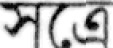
সত্রে
